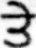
ਤੇ
